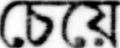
চেয়ে
